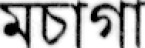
মচাগা
